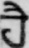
ਹੈ
